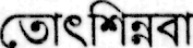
তোৎশিন্নবা
